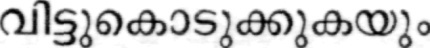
വിട്ടുകൊടുക്കുകയും
